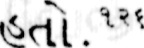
હતો.૧૨૬
